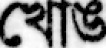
খোঙ
